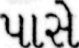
પાસે
